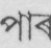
পাৰ
